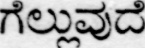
ಗೆಲ್ಲುವುದೆ
